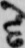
દે
